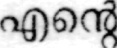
എന്റെ
